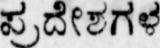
ಪ್ರದೇಶಗಳ
